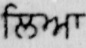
ਲਿਆ
